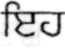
ਇਹ
